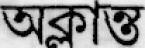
অক্লান্ত
